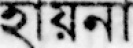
হায়না
